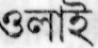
ওলাই
